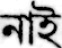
নাই
